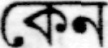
কেন
